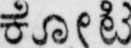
ಕೋಟಿ
